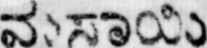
ಮಸಾಯಿ
